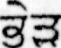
ਭੇੜ
